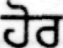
ਹੋਰ
